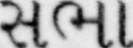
સભા
